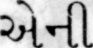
એની
